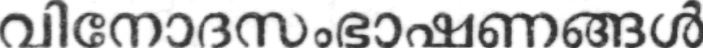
വിനോദസംഭാഷണങ്ങള്‍
